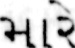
મારે
